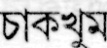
চাকখুম
